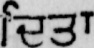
ਦਿਤਾ
